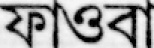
ফাওবা
